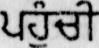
ਪਹੁੰਚੀ
